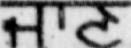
ਜਾਣ
